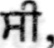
ਸੀ,
